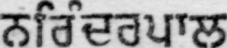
ਨਰਿੰਦਰਪਾਲ
